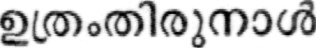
ഉത്രംതിരുനാള്‍
